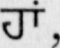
ਹਾਂ,
